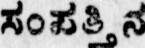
ಸಂಪತ್ತಿನ
